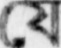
যে
